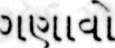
ગણાવો
